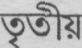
তৃতীয়
